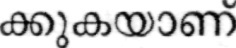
ക്കുകയാണ്
